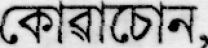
কোৱাচোন,
